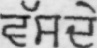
ਵੱਸਦੇ
